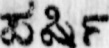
ಪರ್ಷಿ
